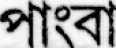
পাংবা
